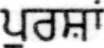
ਪੁਰਸ਼ਾਂ
